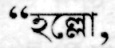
“হল্লো,
